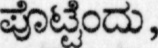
ಪೊಟ್ಟೆಂದು,
